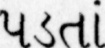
પડતાં
